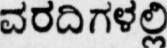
ವರದಿಗಳಲ್ಲಿ
